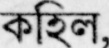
কহিল,
